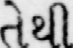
તેથી
